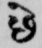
છે
